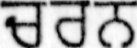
ਚਰਨ
